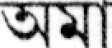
অমা
